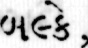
બલ્કે,
